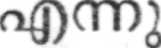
എന്നു
